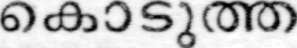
കൊടുത്ത
